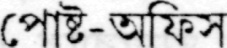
পোষ্ট-অফিস
